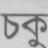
চকু
